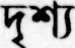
দৃশ্য
